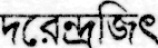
দরেন্দ্রজিৎ
